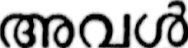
അവള്‍
